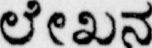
ಲೇಖನ
